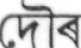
দৌৰ
